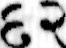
દર
